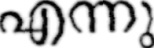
എന്നു
